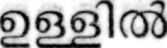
ഉള്ളില്‍
